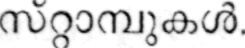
സ്റ്റാമ്പുകള്‍.
